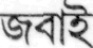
জবাই
